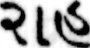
રાહ
